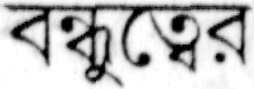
বন্ধুত্বের
